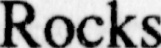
RocKs
